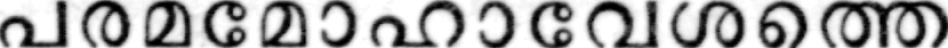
പരമമോഹാവേശത്തെ
